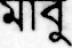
মাবু
